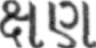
ક્ષણ
